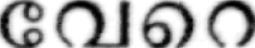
വേറെ
